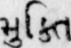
મુક્તિ
